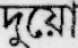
দুয়ো
